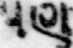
પણ
